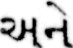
અને
